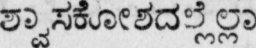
ಶ್ವಾಸಕೋಶದಲ್ಲೆಲ್ಲಾ
